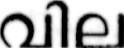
വില
